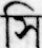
সি
